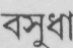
বসুধা
